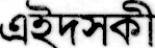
এইদসকী
